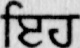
ਇਹ
